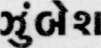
ઝુંબેશ
